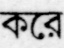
করে
